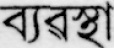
ব্যৱস্হা
